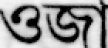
ওজা
